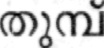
തുമ്പ്
